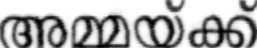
അമ്മയ്ക്ക്
